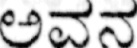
ಅವನ
